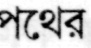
পথের
